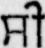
ਸੀ
